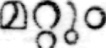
മറ്റും
